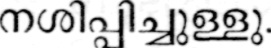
നശിപ്പിച്ചുള്ളു.
